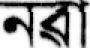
নবা
